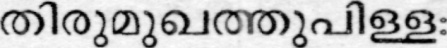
തിരുമുഖത്തുപിള്ള:
